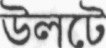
উলটে
